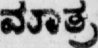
ಮಾತ್ರ
